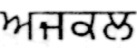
ਅਜਕਲ
